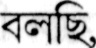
বলছি,
